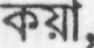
কয়া,
